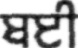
ਬਈ
